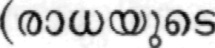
(രാധയുടെ
